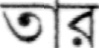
তার
